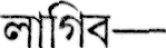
লাগিব-
